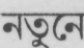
নতুনে
